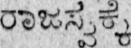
ರಾಜಸ್ವಕ್ಕೆ
